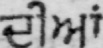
ਦੀਆਂ
